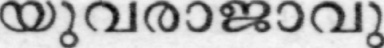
യുവരാജാവു
